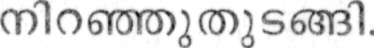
നിറഞ്ഞുതുടങ്ങി.
